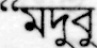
“মদুসু
